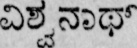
ವಿಶ್ವನಾಥ್
